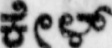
ಕೇಳ್
